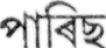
পাৰিছ
